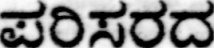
ಪರಿಸರದ
